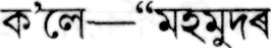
ক'লে-"মহমুদৰ
